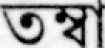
তম্বা
